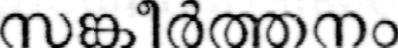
സങ്കീര്‍ത്തനം
